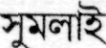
সুমলাই
